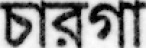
চারগা
